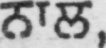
ਨਾਲ,
